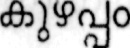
കുഴപ്പം
